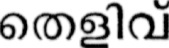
തെളിവ്
